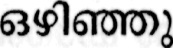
ഒഴിഞ്ഞു
